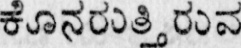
ಕೊನರುತ್ತಿರುವ
